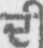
ਦੀ
